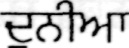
ਦੁਨੀਆ
